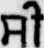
ਸੀ
